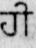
ਹੀ
